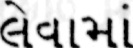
લેવામાં
